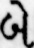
બે
